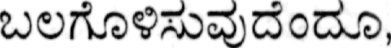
ಬಲಗೊಳಿಸುವುದೆಂದೂ,
